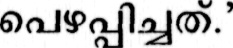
പെഴപ്പിച്ചത്.’
